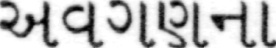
અવગણના
